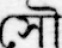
সৌ
